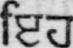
ਇਹ
